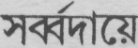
সৰ্ব্বদায়ে
